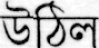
উঠিল
